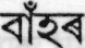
বাঁহৰ
